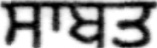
ਸਾਬਤ
